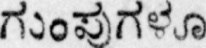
ಗುಂಪುಗಳೂ
